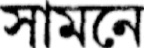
সামনে
